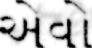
એવો
